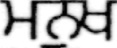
ਮਨੁਖ
